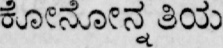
ಕೋನೋನ್ನತಿಯ
